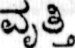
ವೃತ್ತಿ
